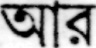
আর
